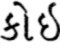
કોઈ
